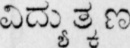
ವಿದ್ಯುತ್ಕಣ
